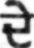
ਦੇ
